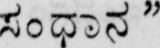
ಸಂಧಾನ”
